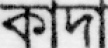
কাদা
